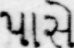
પાસે
